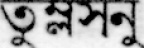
তু্ম্লসনু
